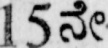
15ನೇ
